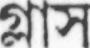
গ্লাস
